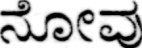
ನೋವು
